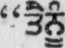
''ਤੈਨੂੰ
